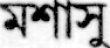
মশাসু
